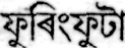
ফুৰিংফুটা
